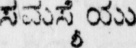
ಸಮಸ್ಯೆಯು
